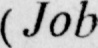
(Job
